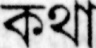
কথা
